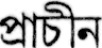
প্রাচীন
